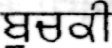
ਬੁਚਕੀ
